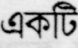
একটি
